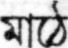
মাঠে
